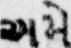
અમે
